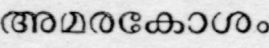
അമരകോശം
